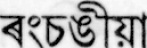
ৰংচঙীয়া
